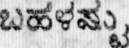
ಬಹಳಷ್ಟು
